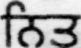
ਨਿਤ
